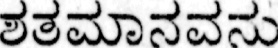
ಶತಮಾನವನು
